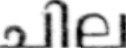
ചില
